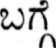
ಬಗ್ಗೆ
